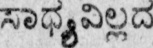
ಸಾಧ್ಯವಿಲ್ಲದ
